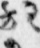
ક્રુર
